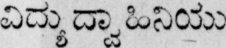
ವಿದ್ಯುದ್ವಾಹಿನಿಯು
